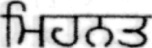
ਮਿਹਨਤ
